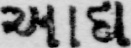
આધ
